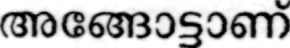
അങ്ങോട്ടാണ്
